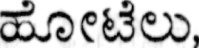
ಹೋಟೆಲು,
